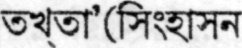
তখ্‌তা’(সিংহাসন
